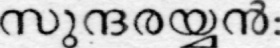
സുന്ദരയ്യന്‍:
